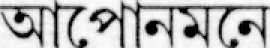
আপোনমনে
